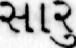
સારુ
